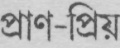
প্ৰাণ-প্ৰিয়
